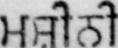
ਮਸ਼ੀਨੀ
